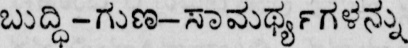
ಬುದ್ಧಿ-ಗುಣ-ಸಾಮರ್ಥ್ಯಗಳನ್ನು
